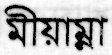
মীয়াম্না
